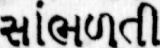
સાંભળતી
